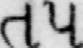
તપ
